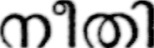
നീതി
